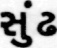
સુંઢ
